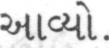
આવ્યો.
